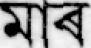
মাৰ
